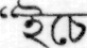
“ইচে
